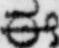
ಈ
